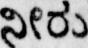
ನೀರು
